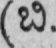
(ಬಿ.
